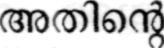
അതിന്റെ
